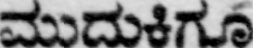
ಮುದುಕಿಗೂ
